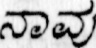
ನಾವು
